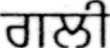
ਗਲੀ
